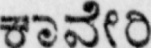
ಕಾವೇರಿ
